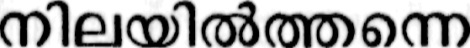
നിലയില്‍ത്തന്നെ
